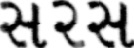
સરસ
